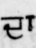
ਦਾ
